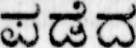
ಪಡೆದ
